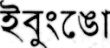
ইবুংঙো
